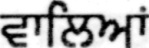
ਵਾਲਿਆਂ
